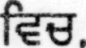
ਵਿਚ,
